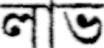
লাভ
